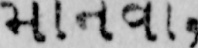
માનવા,
